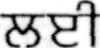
ਲਈ
